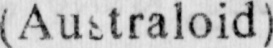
(Auatraloid)
